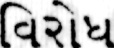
વિરોધ
